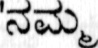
‘ನಮ್ಮ
